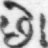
છો
